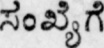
ಸಂಖ್ಯೆಗೆ
